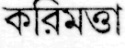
করিমত্তা
